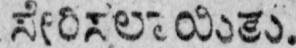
ಸೇರಿಸಲಾಯಿತು.
